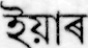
ইয়াৰ
